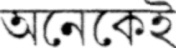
অনেকেই
